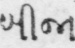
બીજા
